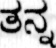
ತನ್ನ
